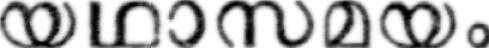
യഥാസമയം
